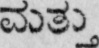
ಮತ್ತು
